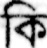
কি
